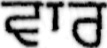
ਵਾਰ
